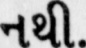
નથી.
